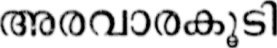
അരവാരകൂടി
